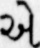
એ
